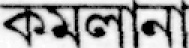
কমলানা
